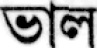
ভাল
